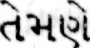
તેમણે
